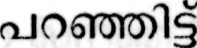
പറഞ്ഞിട്ട്
